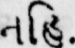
નહિ.
